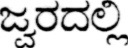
ಜ್ವರದಲ್ಲಿ
